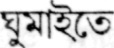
ঘুমাইতে
